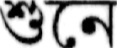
শুনে
